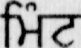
ਮਿੰਟ
